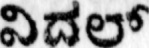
ವಿದಲ್
